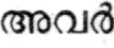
അവര്‍
